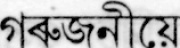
গৰুজনীয়ে
